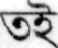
তই
